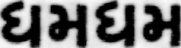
ધમધમ
